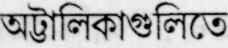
অট্টালিকাগুলিতে
